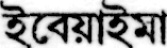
ইবেয়াইমা
